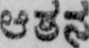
ಆತನ
